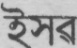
ইসৱ
